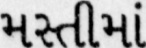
મસ્તીમાં
